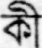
কী
